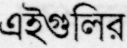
এইগুলির
